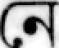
নে
